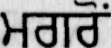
ਮਗਰੋਂ
